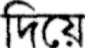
দিয়ে
